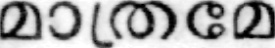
മാത്രമേ
